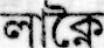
লাক্নৈ
